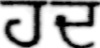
ਹਦ
